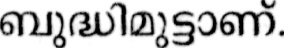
ബുദ്ധിമുട്ടാണ്.
